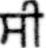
ਸੀ
